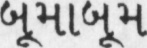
બૂમાબૂમ
